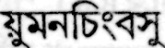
য়ুমনচিংবসু
